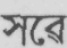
সৱে
